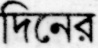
দিনের
